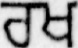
ਰਖ
